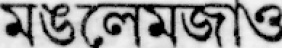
মঙলেমজাও
